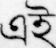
এই
